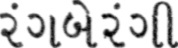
રંગબેરંગી
